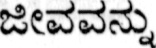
ಜೀವವನ್ನು
